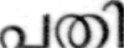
പതി
